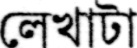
লেখাটা
